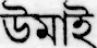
উমাই
